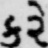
કરે
